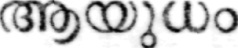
ആയുധം
